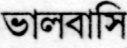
ভালবাসি
